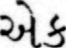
એક
